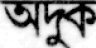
অদুক
